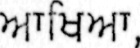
ਆਖਿਆ,
